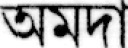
অমদা
